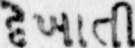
દેખાતી
